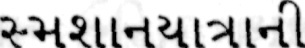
સ્મશાનયાત્રાની
